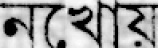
নখোয়
